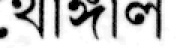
থোঙ্গাল
